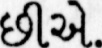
છીએ.
